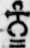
ਨੂੰ
